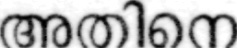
അതിനെ
